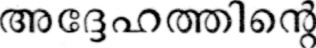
അദ്ദേഹത്തിന്റെ
